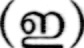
(ഇ)
